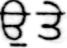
ਉਤੇ
